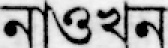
নাওখন
